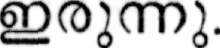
ഇരുന്നു.
